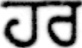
ਹਰ
